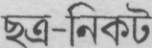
ছত্ৰ-নিকট
